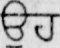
ਉਹ
